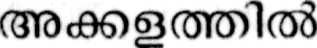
അക്കളത്തില്‍
